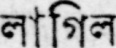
লাগিল
